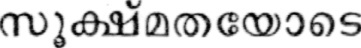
സൂക്ഷ്മതയോടെ
